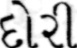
દોરી
